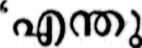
‘എന്തു
